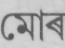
মোৰ
